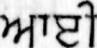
ਆਈ
